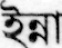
ইন্না
